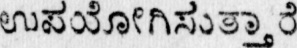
ಉಪಯೋಗಿಸುತ್ತಾರೆ
